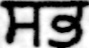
ਸਭ
